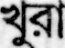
খুরা
